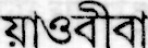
য়াওবীবা
